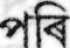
পৰি
